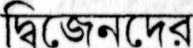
দ্বিজেনদের
